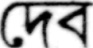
দেব
